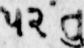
પરંતુ
